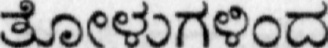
ತೋಳುಗಳಿಂದ
